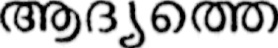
ആദ്യത്തെ
